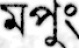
মপুং
